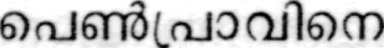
പെണ്‍പ്രാവിനെ
